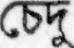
চেদু
